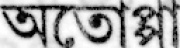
অতোপ্পা
